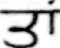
ਤਾਂ
